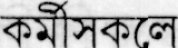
কৰ্মীসকলে
